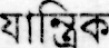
যান্ত্রিক
